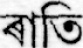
ৰাতি
